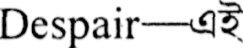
Despair-এই
